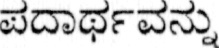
ಪದಾರ್ಥವನ್ನು
